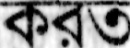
করত
